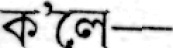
ক'লে-
